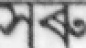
সৰু
